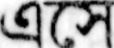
এসে
